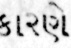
કારણે
